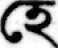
হে
